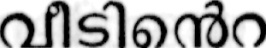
വീടിന്റെ
